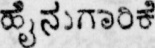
ಹೈನುಗಾರಿಕೆ
